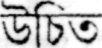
উচিত
